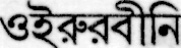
ওইরুরবীনি
